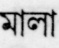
মালা
